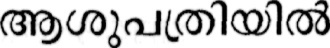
ആശുപത്രിയില്‍
